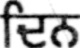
ਦਿਨ
